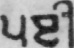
ਪਈ
